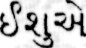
ઇશુએ
